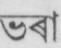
ভৰা
